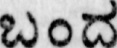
ಬಂದ
